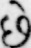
છે
